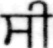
ਸੀ
